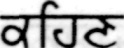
ਕਹਿਣ
